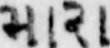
મારા
